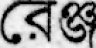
রেঞ্জ
